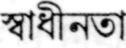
স্বাধীনতা
